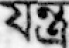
যন্ত্র
